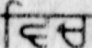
ਵਿਚ
